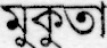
মুকুতা
